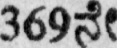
369ನೇ
